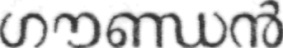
ഗൗണ്ഡന്‍
